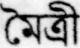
মৈত্রী
